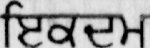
ਇਕਦਮ
